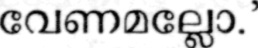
വേണമല്ലോ.'
